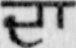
ਦਾ
